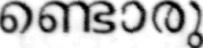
ണ്ടൊരു
